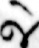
જે
